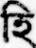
হি
